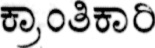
ಕ್ರಾಂತಿಕಾರಿ
